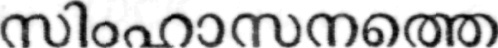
സിംഹാസനത്തെ
